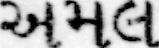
અમલ
